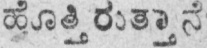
ಹೊತ್ತಿರುತ್ತಾನೆ
